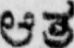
ಆತ
